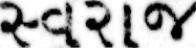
સ્વરાજ
